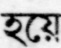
হয়ে
